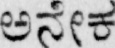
ಅನೇಕ
